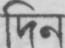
দিন
